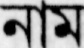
নাম
